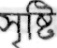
সৃষ্টি
